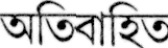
অতিবাহিত
